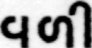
વળી
